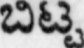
ಬಿಟ್ಟ
